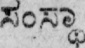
ಸಂಸ್ಥಾ
